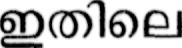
ഇതിലെ
